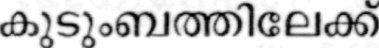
കുടുംബത്തിലേക്ക്
